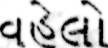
વહેલો
